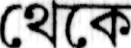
থেকে
